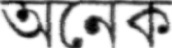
অনেক
